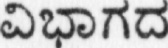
ವಿಭಾಗದ
